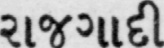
રાજગાદી
